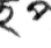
হ
